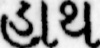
હાથ
